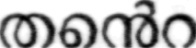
തന്റെ
